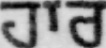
ਹਾਰ
